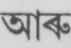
আৰু
